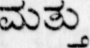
ಮತ್ತು
